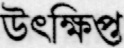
উৎক্ষিপ্ত
